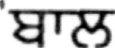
'ਬਾਲ
